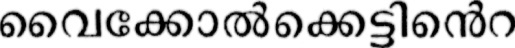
വൈക്കോല്‍ക്കെട്ടിന്റെ
